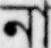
না
